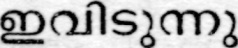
ഇവിടുന്നു
